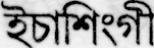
ইচাশিংগী
